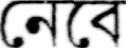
নেবে
